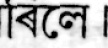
ধৰিলে
